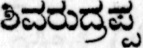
ಶಿವರುದ್ರಪ್ಪ
